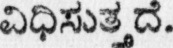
ವಿಧಿಸುತ್ತದೆ.
